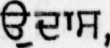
ਉਦਾਸ,
